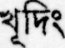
খূদিং
